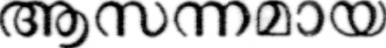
ആസന്നമായ
